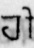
ਹੀ
